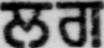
ਲਗ
